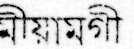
মীয়ামগী
